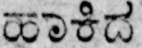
ಹಾಕಿದ
